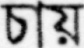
চায়
